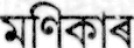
মণিকাৰ
